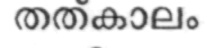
തത്കാലം
